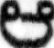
ಆ
